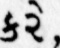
કરે,
